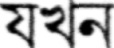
যখন
